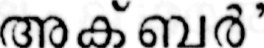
അക്ബര്‍’
